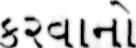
કરવાનો
